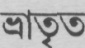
ভ্ৰাতৃত
